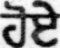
ਹੋਏ
